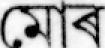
মোৰ
